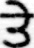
ਤੇ
